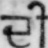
ਦੀ
